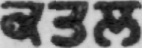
ਕਤਲ
